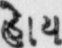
હોય
